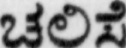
ಚಲಿಸೆ
